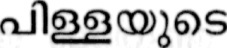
പിള്ളയുടെ
